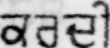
ਕਰਦੀ
